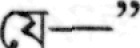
যে-"
